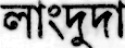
লাংদুদা
